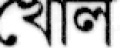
খোল
